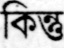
কিন্তু
